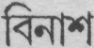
বিনাশ
